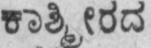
ಕಾಶ್ಮೀರದ
